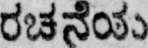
ರಚನೆಯ
